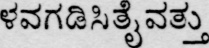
ಳವಗಡಿಸಿತೈವತ್ತು
